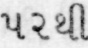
પરથી
